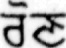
ਰੋਣ
